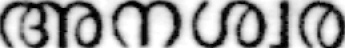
അനശ്വര
